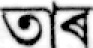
তাৰ
